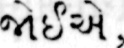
જોઈએ,
